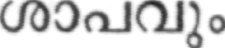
ശാപവും
